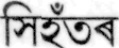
সিহঁতৰ
